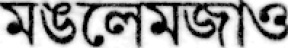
মঙলেমজাও
